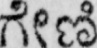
ಗೇಣಿ
